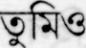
তুমিও
